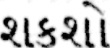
શકશો
